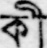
কী
